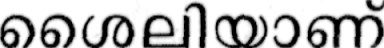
ശൈലിയാണ്
